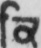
ਕਿ
